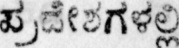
ಪ್ರದೇಶಗಳಲ್ಲಿ
